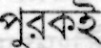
পুরকই
